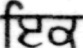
ਇਕ
